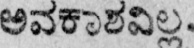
ಅವಕಾಶವಿಲ್ಲ.
